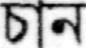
চান
